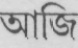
আজি
